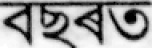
বছৰত
